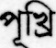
পূখ্রি
